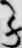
કે
